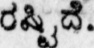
ರಷ್ಟಿದೆ.
